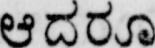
ಆದರೂ
